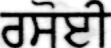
ਰਸੋਈ
